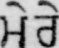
ਮੇਰੇ
